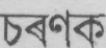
চৰণক
